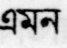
এমন
